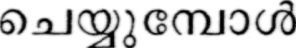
ചെയ്യുമ്പോള്‍
